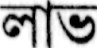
লাভ
